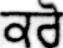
ਕਰੋ
